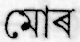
মোৰ
